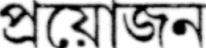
প্রয়োজন
